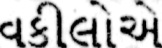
વકીલોએ
